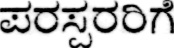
ಪರಸ್ಪರರಿಗೆ
